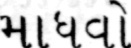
માધવો
